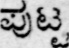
ಪುಟ್ಟ
